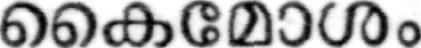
കൈമോശം
